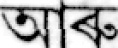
আৰু
